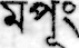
মপূং
